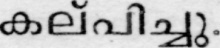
കല്പിച്ചു.
